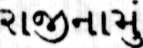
રાજીનામું
